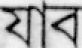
যাব
